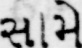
સામે
